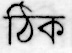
ঠিক
